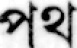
পথ
